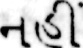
નહીં
